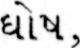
ઘોષ,
